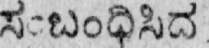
ಸಂಬಂಧಿಸಿದ
